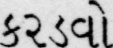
કરડવો
